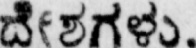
ದೇಶಗಳು.
